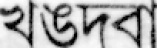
খঙদবা
